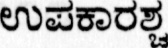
ಉಪಕಾರಶ್ಚ
